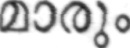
മാരും
